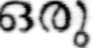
ഒരു
